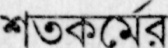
শতকর্মের
